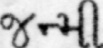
જન્મી
